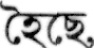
হৈছে,
